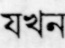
যখন
